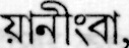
য়ানীংবা,
